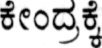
ಕೇಂದ್ರಕ್ಕೆ
